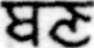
ਬਣ
